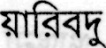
য়ারিবদু
